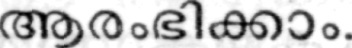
ആരംഭിക്കാം.
